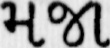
મજા
